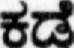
ಕಡೆ
